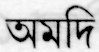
অমদি
